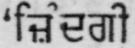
ਜ਼ਿੰਦਗੀ
